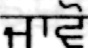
ਜਾਵੋ
